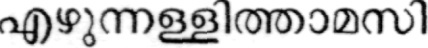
എഴുന്നള്ളിത്താമസി
